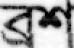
ব্রশ
